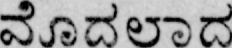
ಮೊದಲಾದ
